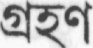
গ্রহণ
